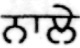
ਨਾਲੇ
